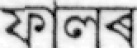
ফালৰ
